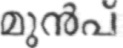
മുന്‍പ്
